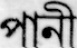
পানী
